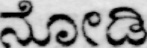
ನೋಡಿ
